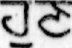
ਹੁਣ
